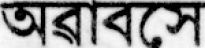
অৱাবসে
